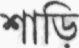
শাড়ি
